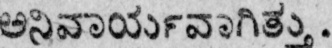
ಅನಿವಾರ್ಯವಾಗಿತ್ತು.
